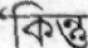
'কিন্তু
